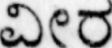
ವೀರ
